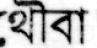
থৌবা
